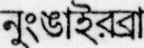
নুংঙাইরব্রা
